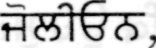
ਜੋਲੀਓਨ,
